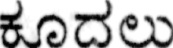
ಕೂದಲು
